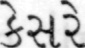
કેસરે
